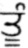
ਤੂੰ
